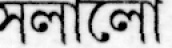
সলালো
